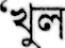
‘খুল
